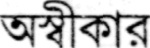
অস্বীকার
